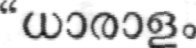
“ധാരാളം
